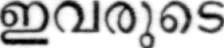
ഇവരുടെ
